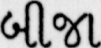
બીજા
